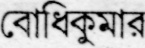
বোধিকুমার
